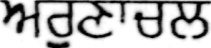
ਅਰੁਣਾਚਲ
